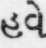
હવે
